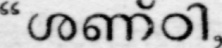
"ശണ്ഠി,
